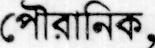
পৌরানিক,
